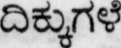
ದಿಕ್ಕುಗಳೆ
